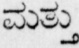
ಮತ್ತು
